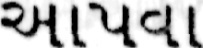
આપવા
